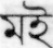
মই
